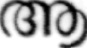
ആ
